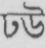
ঢউ
